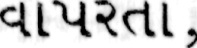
વાપરતા,
